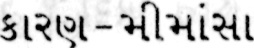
કારણ-મીમાંસા
